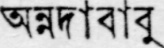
অন্নদাবাবু
